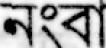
নংবা
